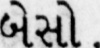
બેસો.
